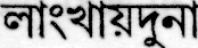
লাংখায়দুনা
